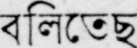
বলিতেছ
